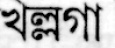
খিল্লগা
